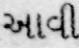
આવી
